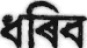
ধৰিব
